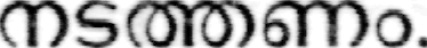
നടത്തണം.
